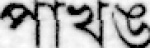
পাখঙ
